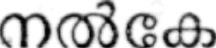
നല്‍കേ
